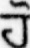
ਹੋ
